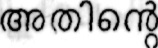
അതിന്റെ
